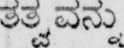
ತತ್ವವನ್ನು
